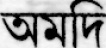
অমদি
